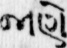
જાણે
